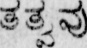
ತತ್ವವು
